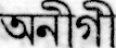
অনীগী
